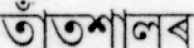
তাঁতশালৰ
